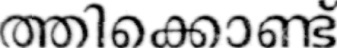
ത്തിക്കൊണ്ട്
